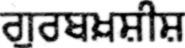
ਗੁਰਬਖ਼ਸ਼ੀਸ਼
